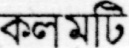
কলমটি
